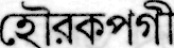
হৌরকপগী
